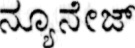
ನ್ಯೂನೇಜ್
